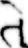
તે
